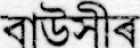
বাউসীৰ
